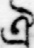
ঐ
